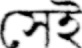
সেই
